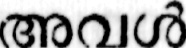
അവള്‍
